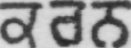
ਕਰਨ
